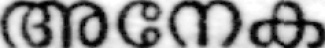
അനേക
